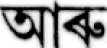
আৰু
